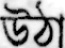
উঠা
